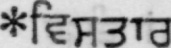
*ਵਿਸਤਾਰ
